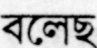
বলেছ
